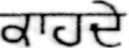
ਕਾਹਦੇ
